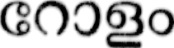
റോളം
